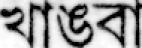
খাঙবা
